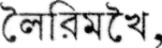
লৈরিমখৈ,
